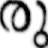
രു
